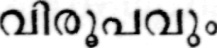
വിരൂപവും
